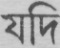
যদি
